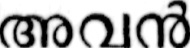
അവന്‍
